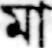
মা
